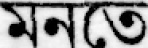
মনতে
